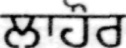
ਲਾਹੌਰ
